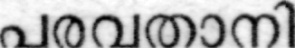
പരവതാനി
